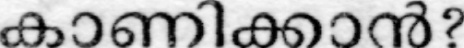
കാണിക്കാന്‍?
